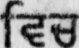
ਵਿਚ
